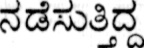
ನಡೆಸುತ್ತಿದ್ದ
